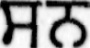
ਸਨ
